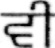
ਵੀ
